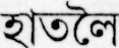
হাতলৈ
